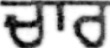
ਚਾਰ
